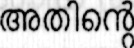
അതിന്റെ
